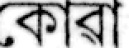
কোৱা
